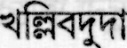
খল্লিবদুদা
